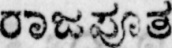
ರಾಜಪೂತ
